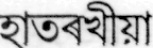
হাতৰখীয়া
